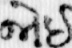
જોઈ
